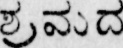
ಶ್ರಮದ
